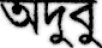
অদুবু
